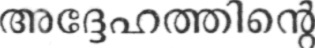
അദ്ദേഹത്തിന്റെ
